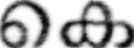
കെ
